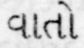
વાતો
